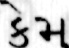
કેમ
